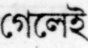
গেলেই
